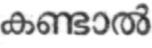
കണ്ടാല്‍
